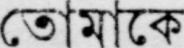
তোমাকে
